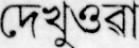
দেখুওৱা
